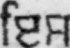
ਇਸ
